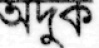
অদুক
